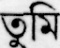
তুমি
